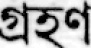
গ্রহণ
